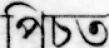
পিচত
